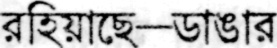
রহিয়াছে—ডাঙার
